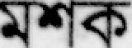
মশক
